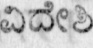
ವಿದೇಶಿ
